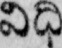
ವಿಧಿ
